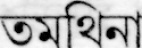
তমথিনা
